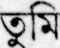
তুমি
